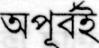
অপূৰ্বই
